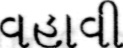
વહાવી
